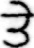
ਤੇ
